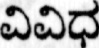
ವಿವಿಧ
